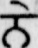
ਨੇ
